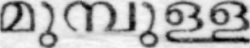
മുമ്പുള്ള
